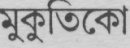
মুকুতিকো
